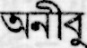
অনীবু
